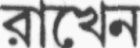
রাখেন
